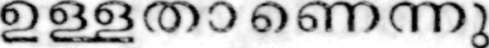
ഉള്ളതാണെന്നു
